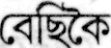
বেছিকৈ
